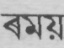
ৰময়
